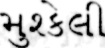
મુશ્કેલી
